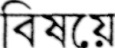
বিষয়ে
